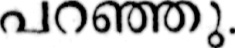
പറഞ്ഞു.
